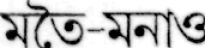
মতৈ-মনাও
